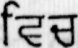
ਵਿਚ
